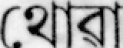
থোৱা
